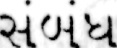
સંબંધ
